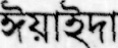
ঈয়াইদা
